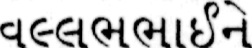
વલ્લભભાઈને
